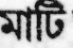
মাটি
